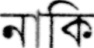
নাকি
